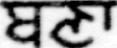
ਬਣਾ
